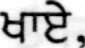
ਖਾਏ,
